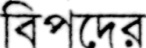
বিপদের
